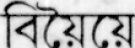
বিয়ৈয়ে
